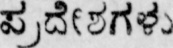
ಪ್ರದೇಶಗಳು
